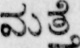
ಮತ್ತೆ
